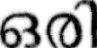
ഒരി
